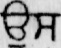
ਉਸ
